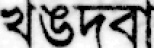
খঙদবা
